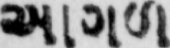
આગળ
